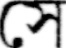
সে
